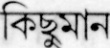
কিছুমান
